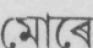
মোৰে
